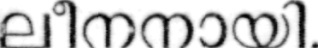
ലീനനായി.
